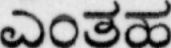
ಎಂತಹ
